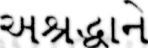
અશ્રદ્ધાને
